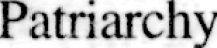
Patriarchy
